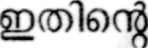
ഇതിന്റെ
